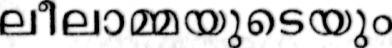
ലീലാമ്മയുടെയും
